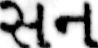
સન
